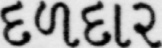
દળદાર
